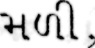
મળી,
